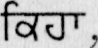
ਕਿਹਾ,
